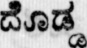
ದೊಡ್ಡ
